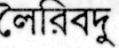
লৈরিবদু
